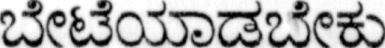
ಬೇಟೆಯಾಡಬೇಕು
